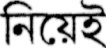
নিয়েই
